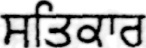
ਸਤਿਕਾਰ
